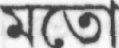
মতো
